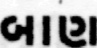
બાણ
